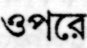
ওপরে
